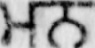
ਮਨ
